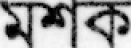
মশক
